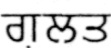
ਗ਼ਲਤ
